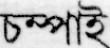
চম্পাই
